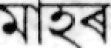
মাহৰ
